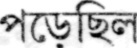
পড়েছিল
